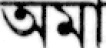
অমা
